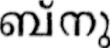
ബ്നു
